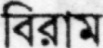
বিরাম
